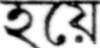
হয়ে
